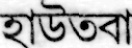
হাউতবা
